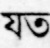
যত
